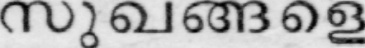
സുഖങ്ങളെ
